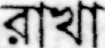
রাখা
